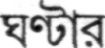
ঘণ্টার
